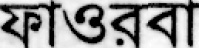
ফাওরবা
